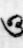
ও
